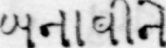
બનાવીને
